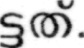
ട്ടത്.
